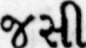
જસી
